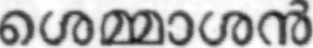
ശെമ്മാശന്‍
